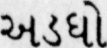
અડધો
